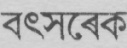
বৎসৰেক
